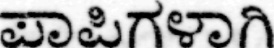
ಪಾಪಿಗಳಾಗಿ
